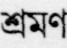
শ্রমণ
